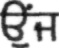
ਉਂਜ
